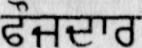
ਫੌਜਦਾਰ
